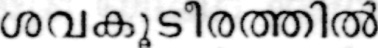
ശവകുടീരത്തില്‍
